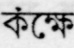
কক্ষে
